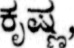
ಕೃಷ್ಣ,
